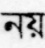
নয়
